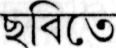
ছবিতে
